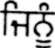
ਜਿਨੂੰ
